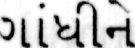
ગાંધીને
